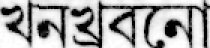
খনখ্রবনো
